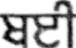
ਬਈ
